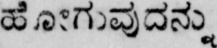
ಹೋಗುವುದನ್ನು
